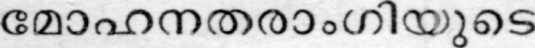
മോഹനതരാംഗിയുടെ
